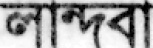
লান্দবা
